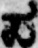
ವ
